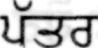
ਪੱਤਰ
